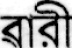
ৱারী
